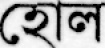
হোল
